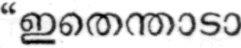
"ഇതെന്താടാ
